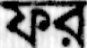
ফর
